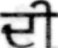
ਦੀ
